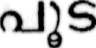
പൂട
